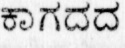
ಕಾಗದದ
